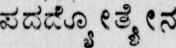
ಪದದ್ಯೋತ್ಯೇನ
